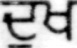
ਦੁਖ
